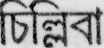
চিল্লিবা
